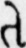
તે
